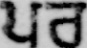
ਪਰ
